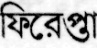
ফিরেপ্তা
